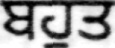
ਬਹੁਤ
